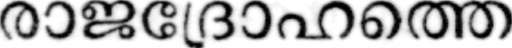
രാജദ്രോഹത്തെ
